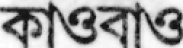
কাওবাও
